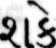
શકે
